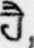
ਹੈ,
